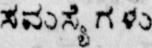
ಸಮಸ್ಯೆಗಳು
